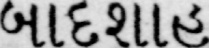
બાદશાહ
